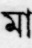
মা
